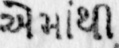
એમાંથી
